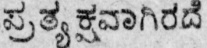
ಪ್ರತ್ಯಕ್ಷವಾಗಿರದೆ
